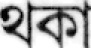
থকা
